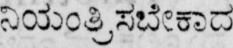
ನಿಯಂತ್ರಿಸಬೇಕಾದ
